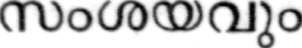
സംശയവും
